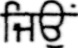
ਜਿਉਂ
